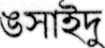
ঙসাইদু
